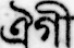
ঐগী
